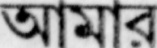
আমার
